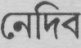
নেদিব
